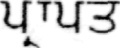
ਪ੍ਰਾਪਤ
